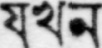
যখন
